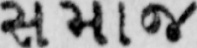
સમાજ
